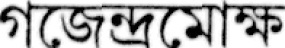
গজেন্দ্রমোক্ষ
